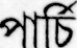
পার্চি
